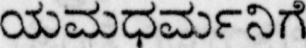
ಯಮಧರ್ಮನಿಗೆ
